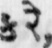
કરે,
